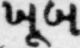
ખૂબ
